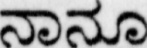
ನಾನೂ
